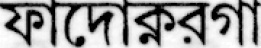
ফাদোক্নরগা
